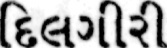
દિલગીરી
